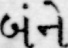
બંને
